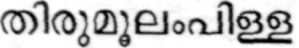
തിരുമൂലംപിള്ള
